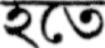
হতে
